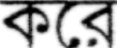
করে
